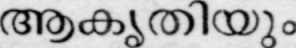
ആകൃതിയും
